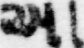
આ
